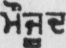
ਮੌਜੂਦ
